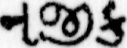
નજીક
